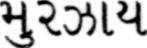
મુરઝાયા
